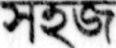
সহজ
